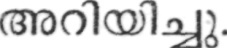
അറിയിച്ചു.
